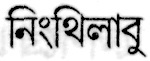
নিংথিলাবু
